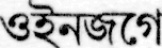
ওইনজগে
